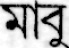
মাবু
